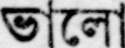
ভালো
